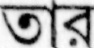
তার
